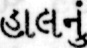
હાલનું
